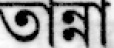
তান্না
